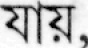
যায়,
